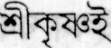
শ্রীকৃষ্ণই
